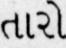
તારો
